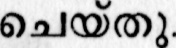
ചെയ്തു.
